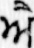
ਐ
